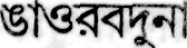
ঙাওরবদুনা
